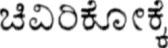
ಚಿವಿರಿಕೋಕ್ಕೆ
